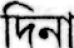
দিনা
